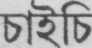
চাইচি
